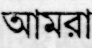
আমরা
